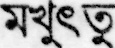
মখুৎতু
